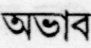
অভাব
